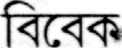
বিবেক
